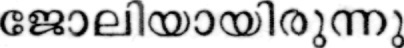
ജോലിയായിരുന്നു
